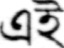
এই
